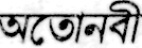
অতোনবী
